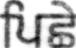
ਪਿਛੇ
